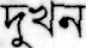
দুখন
